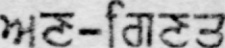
ਅਣ-ਗਿਣਤ
